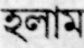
হলাম
